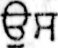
ਉਸ
